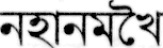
নহানমখৈ
